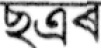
ছত্রৰ
